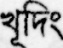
খূদিং
